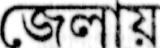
জেলায়
